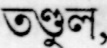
তণ্ডুল,
